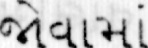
જોવામાં
